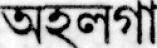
অহলগা
